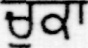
ਚੁਕਾ
